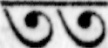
তত
